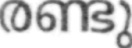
രണ്ടു
